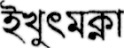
ইখুৎমক্না
